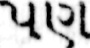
પણ
